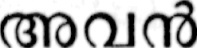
അവന്‍
